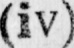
(iv)
